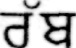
ਰੱਬ
